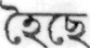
হৈছে
